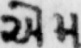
એમ
